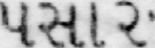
પસાર
